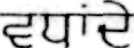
ਵਧਾਂਦੇ
